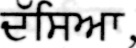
ਦੱਸਿਆ,
